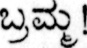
ಬ್ರಮ್ಮ!
